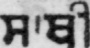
ਸਾਥੀ
